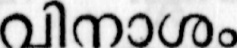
വിനാശം
